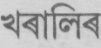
খৰালিৰ
